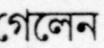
গেলেন
